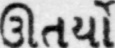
ઊતર્યો
